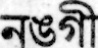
নঙগী
